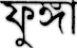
ফুঙ্গা
